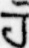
ਹੋ
